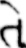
તે
